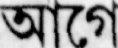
আগে
